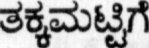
ತಕ್ಕಮಟ್ಟಿಗೆ
